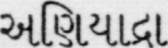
અણિયાદ્રા
